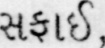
સફાઈ,
